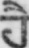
ਹੈ
